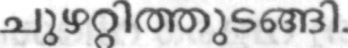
ചുഴറ്റിത്തുടങ്ങി.
